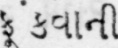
ફૂંકવાની
